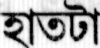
হাতটা
